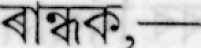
ৰান্ধক,-
